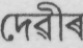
দেৱীৰ
